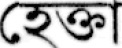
হেক্তা
